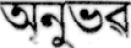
অনুভৱ
